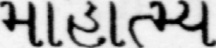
માહાત્મ્ય
